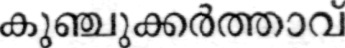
കുഞ്ചുക്കര്‍ത്താവ്
